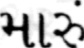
મારું
